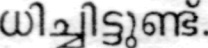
ധിച്ചിട്ടുണ്ട്.
